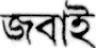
জবাই
